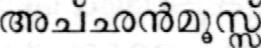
അച്ഛന്‍മൂസ്സ്
